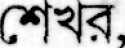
শেখর,
